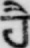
ਹੈ
